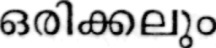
ഒരിക്കലും
